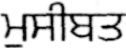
ਮੁਸੀਬਤ
